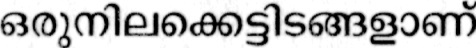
ഒരുനിലക്കെട്ടിടങ്ങളാണ്
